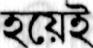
হয়েই
